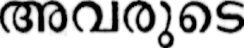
അവരുടെ
